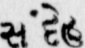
સંદેહ
